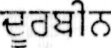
ਦੂਰਬੀਨ
